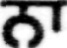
ਨਾ
